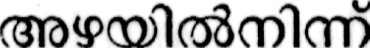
അഴയില്‍നിന്ന്
